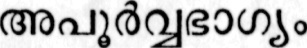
അപൂര്‍വ്വഭാഗ്യം
